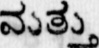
ಮತ್ತು
